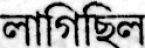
লাগিছিল
